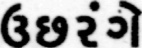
ઉછરંગે
